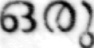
ഒരു
